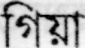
গিয়া
